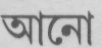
আনো
